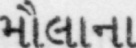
મૌલાના
